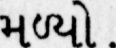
મળ્યો.
